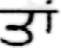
ਤਾਂ
